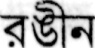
রঙীন
